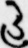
હે
